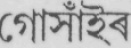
গোসাঁইৰ
